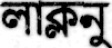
লাক্লনু
